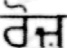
ਰੋਜ਼
